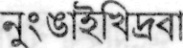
নুংঙাইখিদ্রবা
